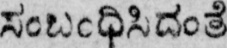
ಸಂಬಂಧಿಸಿದಂತೆ
